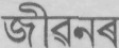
জীৱনৰ
